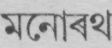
মনোৰথ
